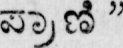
ಪ್ರಾಣಿ”
